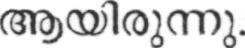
ആയിരുന്നു.
